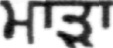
ਮਾੜਾ
